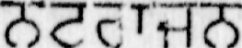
ਨਟਰਾਜਨ
